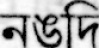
নঙদি
